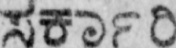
ಸರ್ಕಾರಿ
